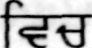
ਵਿਚ
